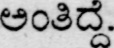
ಅಂತಿದ್ದೆ.
